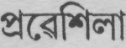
প্ৰৱেশিলা
